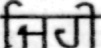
ਜਿਹੀ
